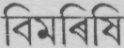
বিমৰিষি
